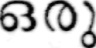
ഒരു
